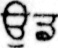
ਉਡ
